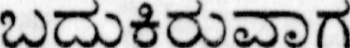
ಬದುಕಿರುವಾಗ
